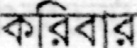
করিবার
